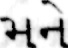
મને
